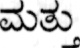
ಮತ್ತು
